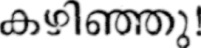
കഴിഞ്ഞു!
